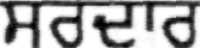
ਸਰਦਾਰ
